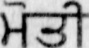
ਮੋਤੀ
